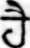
ਹੈ
